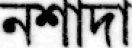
নশাদা
